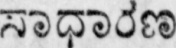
ಸಾಧಾರಣ
